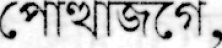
পোত্থাজগে,
